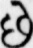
છે
